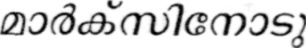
മാര്‍ക്സിനോടു
